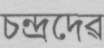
চন্দ্ৰদেৱ
